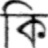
কি
